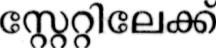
സ്റ്റേറ്റിലേക്ക്
